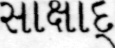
સાક્ષાદ્
